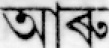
আৰু
